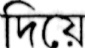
দিয়ে
